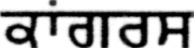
ਕਾਂਗਰਸ
